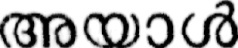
അയാള്‍
